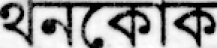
থনকোক
